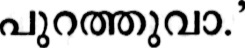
പുറത്തുവാ.'
